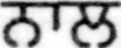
ਨਾਲ
